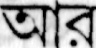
আর
